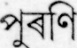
পুৰণি
